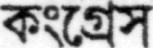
কংগ্রেস
